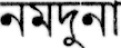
নমদুনা
